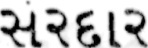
સરદાર
